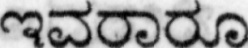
ಇವರಾರೂ
